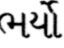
ભર્યો
